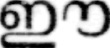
ഈ
